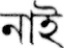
নাই
